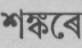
শঙ্কৰে
